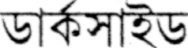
ডার্কসাইড
